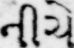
નીચે
